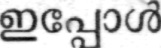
ഇപ്പോള്‍
